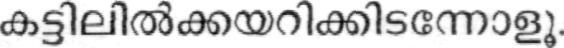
കട്ടിലില്‍ക്കയറിക്കിടന്നോളൂ.
